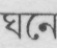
ঘনে
